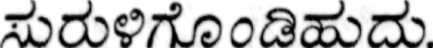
ಸುರುಳಿಗೊಂಡಿಹುದು.
